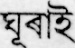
ঘূৰাই
